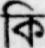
কি
